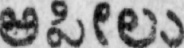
ಅಪೀಲು
